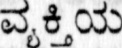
ವ್ಯಕ್ತಿಯ
